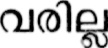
വരില്ല
